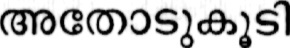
അതോടുകൂടി
